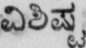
ವಿಶಿಷ್ಟ
